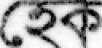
হেক
